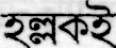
হল্লকই
